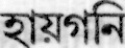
হায়গনি
